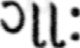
ગાઃ
